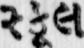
સ્કૂલ
